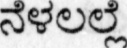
ನೆಳಲಲ್ಲೆ
